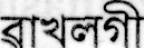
ৱাখলগী
